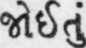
જોઈતું
